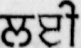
ਲਈ
